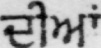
ਦੀਆਂ
